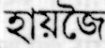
হায়জৈ
